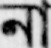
না
